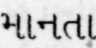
માનતા
